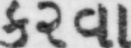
કરવા
